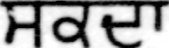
ਸਕਦਾ
